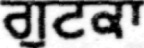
ਗੁਟਕਾ
